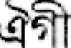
ঐগী
